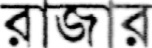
রাজার
